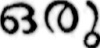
ഒരു
